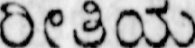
ರೀತಿಯ
